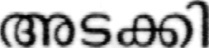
അടക്കി
